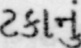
ટકાનું
